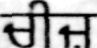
ਚੀਜ਼
